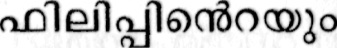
ഫിലിപ്പിന്റെയും
